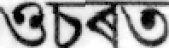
ওচৰত
